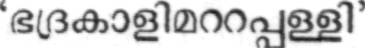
‘ഭദ്രകാളിമററപ്പള്ളി’
